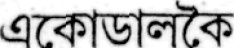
একোডালকৈ
